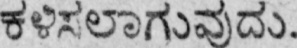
ಕಳಿಸಲಾಗುವುದು.
